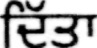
ਦਿੱਤਾ
